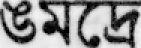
ঙমদ্রে
